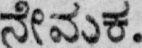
ನೇಮಕ.
